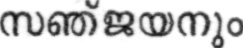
സഞ്ജയനും
